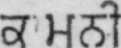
ਕਾਮਨੀ
